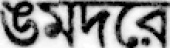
ঙমদরে
